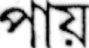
পায়
